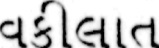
વકીલાત
